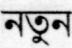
নতুন
